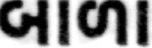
બાળા
